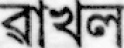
ৱাখল
